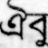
ঐবু
